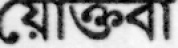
য়োক্তবা
